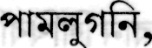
পামলুগনি,
